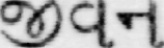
જીવન
